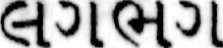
લગભગ
